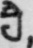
ਹੈ,
